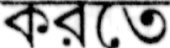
করতে
